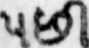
પછી
